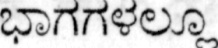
ಭಾಗಗಳಲ್ಲೂ
